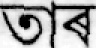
তাৰ
